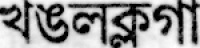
খঙলক্লগা
